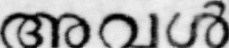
അവള്‍
